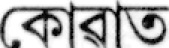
কোৱাত
